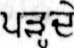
ਪੜ੍ਹਦੇ
